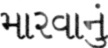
મારવાનું
